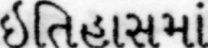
ઈતિહાસમાં
